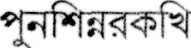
পুনশিন্নরকখি
